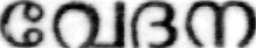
വേദന
